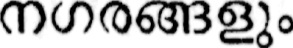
നഗരങ്ങളും
